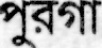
পুরগা
